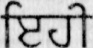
ਇਹੀ
